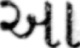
આ
